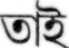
তাই
